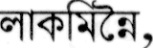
লাকমিন্নৈ,
